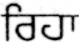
ਰਿਹਾ
